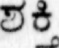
ಶಕ್ತಿ
